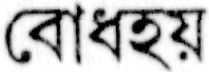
বোধহয়
